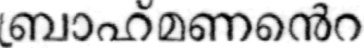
ബ്രാഹ്മണന്റെ
